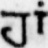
ਹਾਂ
